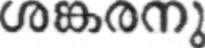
ശങ്കരനു
